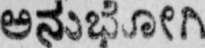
ಅನುಭೋಗಿ
